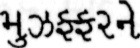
મુઝફ્ફરને
